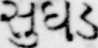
સુઘડ
